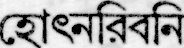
হোৎনরিবনি
